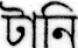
টানি
